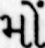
મોં
